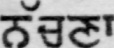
ਨੱਚਣਾ
